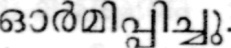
ഓര്‍മിപ്പിച്ചു.
